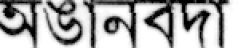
অঙানবদা
